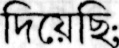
দিয়েছি,
